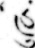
'હું
